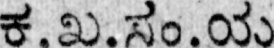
ಕ.ಖ.ಸಂ.ಯ
